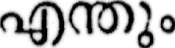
എന്തും
